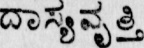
ದಾಸ್ಯವೃತ್ತಿ
